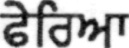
ਫੇਰਿਆ
